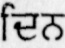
ਦਿਨ
